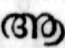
ആ
